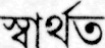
স্বার্থত
